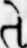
તે
